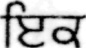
ਇਕ
